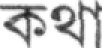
কথা
